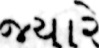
જ્યારે
